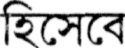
হিসেবে
